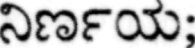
ನಿರ್ಣಯ;
